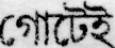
গোটেই
